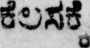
ಕೆಲಸಕ್ಕೆ
